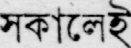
সকালেই
